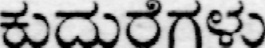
ಕುದುರೆಗಳು
